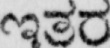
ಇತರ
